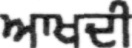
ਆਖਦੀ
